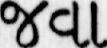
જવા
